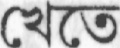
খেতে
